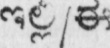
ಇಲ್ಲಿ/ಈ
